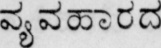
ವ್ಯವಹಾರದ
